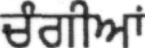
ਚੰਗੀਆਂ
